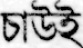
চাউই
